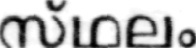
സ്ഥലം
